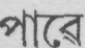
পাৱে
